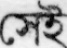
সেই
